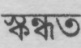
স্কন্ধত
